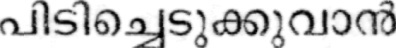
പിടിച്ചെടുക്കുവാന്‍
